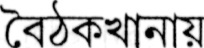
বৈঠকখানায়
